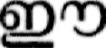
ഈ
